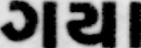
ગયા
